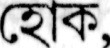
হোক,
